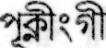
পূক্নীংগী
